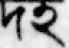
দহ
